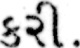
કરી.
